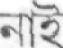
নাই
